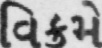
વિક્રમે
